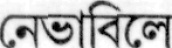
নেভাবিলে
